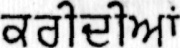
ਕਰੀਦੀਆਂ
